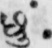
છું.
